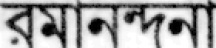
রমানন্দনা
